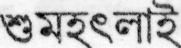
শুমহৎলাই
